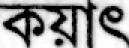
কয়াৎ
